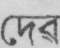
দেৱ
